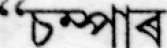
"চম্পাৰ
